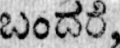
ಬಂದರೆ,
